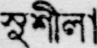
সুশীলা
